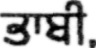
ਭਾਬੀ,
